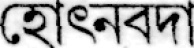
হোৎনবদা
